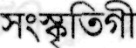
সংস্কৃতিগী
